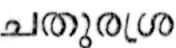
ചതുരശ്ര
